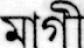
মাগী
